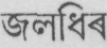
জলধিৰ
